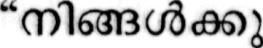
“നിങ്ങള്‍ക്കു
